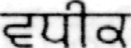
ਵਧੀਕ
